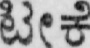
ಟೀಕೆ
